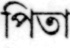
পিতা
